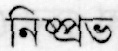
নিষ্প্রভ
